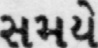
સમયે
